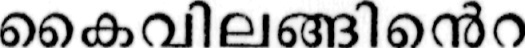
കൈവിലങ്ങിന്റെ
